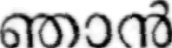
ഞാന്‍
